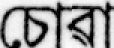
চোৱা
